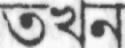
তখন
